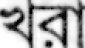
খরা
